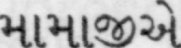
મામાજીએ
